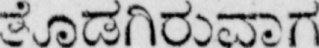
ತೊಡಗಿರುವಾಗ
